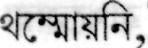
থম্মোয়নি,
